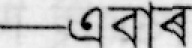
-এবাৰ
